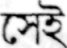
সেই
